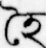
হৈ
